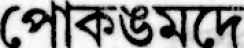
পোকঙমদে
